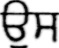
ਉਸ
